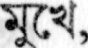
মুখে,
